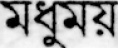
মধুময়
